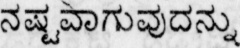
ನಷ್ಟವಾಗುವುದನ್ನು
